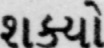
શક્યો
